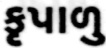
કૃપાળુ
